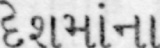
દેશમાંના
